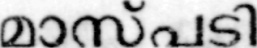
മാസ്പടി
